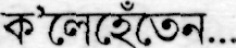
ক'লেহেঁতেন...
